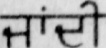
ਜਾਂਦੀ
